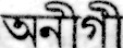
অনীগী
